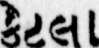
કેટલા
